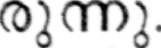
രുന്നു.
